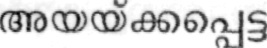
അയയ്ക്കപ്പെട്ട
